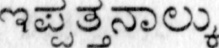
ಇಪ್ಪತ್ತನಾಲ್ಕು
